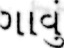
ગાવું
